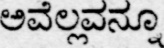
ಅವೆಲ್ಲವನ್ನೂ
